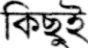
কিছুই
